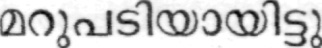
മറുപടിയായിട്ടു
